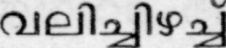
വലിച്ചിഴച്ച്
